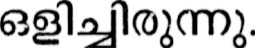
ഒളിച്ചിരുന്നു.
